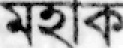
মহাক
